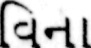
વિના
